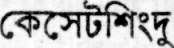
কেসেটশিংদু
